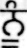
ਨੂੰ
